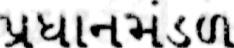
પ્રધાનમંડળ
